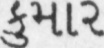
કુમાર
